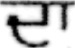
ਦਾ
